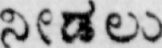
ನೀಡಲು
